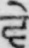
ਵੇ
